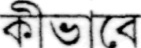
কীভাবে
